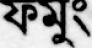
ফমুং
